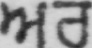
ਅਰ
